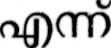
എന്ന്
